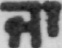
ਜਾ
